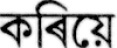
কৰিয়ে
